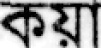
কয়া
